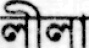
লীলা
